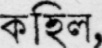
কহিল,
